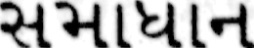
સમાધાન
